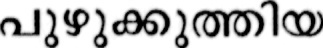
പുഴുക്കുത്തിയ
